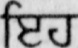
ਇਹ
